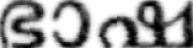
ഭാഷ
